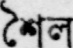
শৈল
